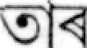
তাৰ
